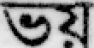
ভয়
